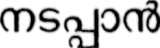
നടപ്പാന്‍
